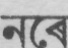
নৰে
